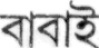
বাবাই
